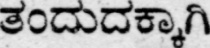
ತಂದುದಕ್ಕಾಗಿ
